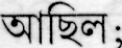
আছিল;
